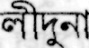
লীদুনা
